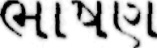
ભાષણ
